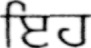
ਇਹ
